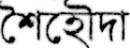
শৈহৌদা
